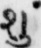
શું
